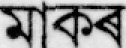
মাকৰ
